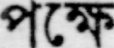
পক্ষে
